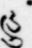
હું
